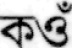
কওঁ
